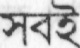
সবই
